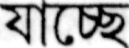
যাচ্ছে
